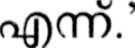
എന്ന്.’
